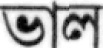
ভাল
